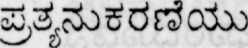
ಪ್ರತ್ಯನುಕರಣೆಯು
